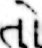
તો
